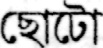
ছোটো
